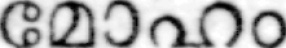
മോഹം
